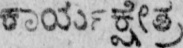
ಕಾರ್ಯಕ್ಷೇತ್ರ
